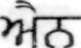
ਐਨ
